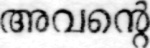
അവന്റെ
